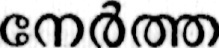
നേര്‍ത്ത
